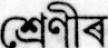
শ্ৰেণীৰ
